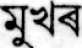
মুখৰ
